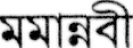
মমান্নবী
